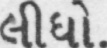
લીધો.
